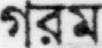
গরম
